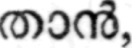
താന്‍,
